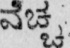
ವೆಚ್ಚ.
